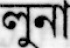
লুনা
